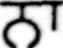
ਨਾ
